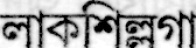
লাকশিল্লগা
